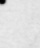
તું
